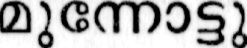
മുന്നോട്ടു
